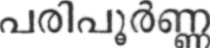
പരിപൂര്‍ണ്ണ
